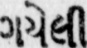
ગયેલી
